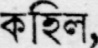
কহিল,
